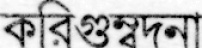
করিগুম্বদনা
